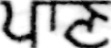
ਪਾਣ
